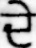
ਦੇ
